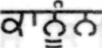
ਕਾਨੂੰਨ
